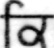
ਕਿ
